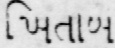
ખિતાબ
